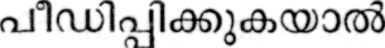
പീഡിപ്പിക്കുകയാല്‍
